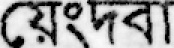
য়েংদবা
